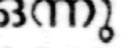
ഒന്നു
